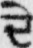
ਦੇ
